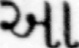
આ
